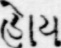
હોય
